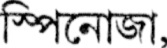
স্পিনোজা,
